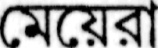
মেয়েরা
